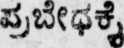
ಪ್ರಬೇಧಕ್ಕೆ
